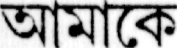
আমাকে
